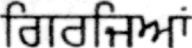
ਗਿਰਜਿਆਂ
